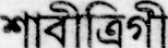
শাবীত্রিগী
